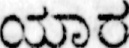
ಯಾರ
